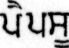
ਪੈਪਸੂ
